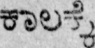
ಕಾಲಕ್ಕೆ
